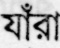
যাঁরা
